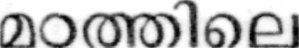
മഠത്തിലെ
